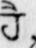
ਹੈ,
